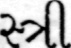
સ્ત્રી
